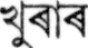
খুৰাৰ
